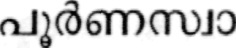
പൂര്‍ണസ്വാ
